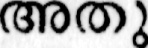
അതു
